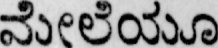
ಮೇಲೆಯೂ
